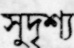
সুদৃশ্য
